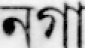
নগা
